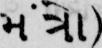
મંત્રો)
